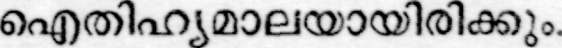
ഐതിഹ്യമാലയായിരിക്കും.
